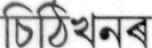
চিঠিখনৰ
